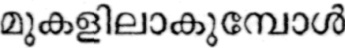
മുകളിലാകുമ്പോള്‍
